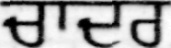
ਚਾਦਰ
